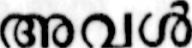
അവള്‍
